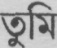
তুমি
